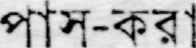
পাস-করা
